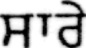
ਸਾਰੇ
